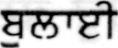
ਬੁਲਾਈ
